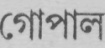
গোপাল
